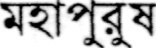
মহাপুরুষ
